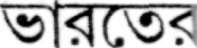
ভারতের
